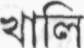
খালি
